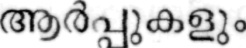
ആര്‍പ്പുകളും
